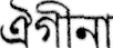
ঐগীনা
